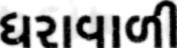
ધરાવાળી
